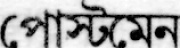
পোস্টমেন
